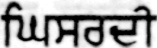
ਘਿਸਰਦੀ
